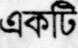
একটি
